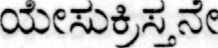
ಯೇಸುಕ್ರಿಸ್ತನೇ
